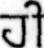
ਹੀ
